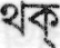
থক্
